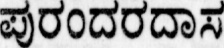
ಪುರಂದರದಾಸ
